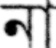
না
